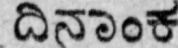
ದಿನಾಂಕ
